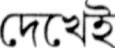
দেখেই
